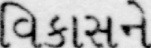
વિકાસને
